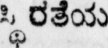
ಸ್ಥಿರತೆಯ
